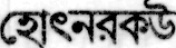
হোৎনরকউ
